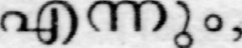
എന്നും,
